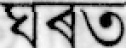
ঘৰত
